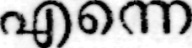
എന്നെ
